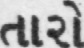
તારો
